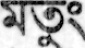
মতুং
